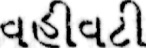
વહીવટી
